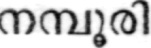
നമ്പൂരി
